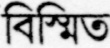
বিস্মিত
